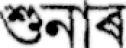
শুনাৰ
